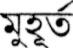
মুহূর্ত
